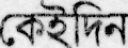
কেইদিন
